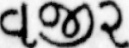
વજીર
